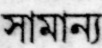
সামান্য
